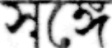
সঙ্গে
